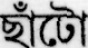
ছাঁটো
